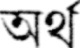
অর্থ
